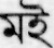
মই
